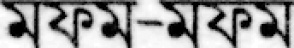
মফম-মফম
